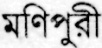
মণিপুরী
